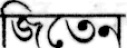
জিতে
